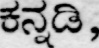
ಕನ್ನಡಿ,
